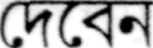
দেবেন
